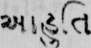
આહુતિ
